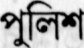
পুলিশ
